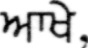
ਆਖੇ,
